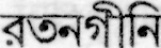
রতনগীনি
